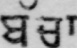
ਬੱਚਾ
